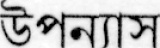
উপন্যাস
